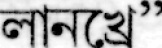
লানখ্রে
